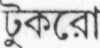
টুকরো
